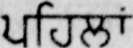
ਪਹਿਲਾਂ
